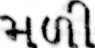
મળી
